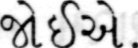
જોઈએ.
